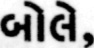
બોલે,
